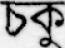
চকু
